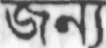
জন্য
